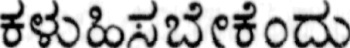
ಕಳುಹಿಸಬೇಕೆಂದು
